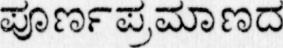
ಪೂರ್ಣಪ್ರಮಾಣದ
